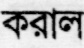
করাল
